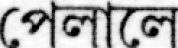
পেলালে
